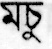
মচু
